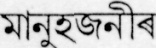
মানুহজনীৰ
